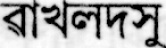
ৱাখলদসু
